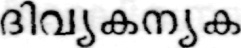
ദിവ്യകന്യക
